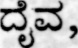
ದೈವ,
